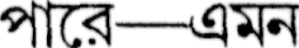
পারে-এমন
